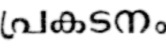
പ്രകടനം
